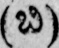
(ಬಿ)
